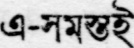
এ-সমস্তই
